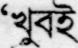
‘খুবই
